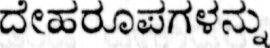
ದೇಹರೂಪಗಳನ್ನು
